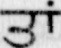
ਤਾਂ
